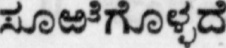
ಸೂಱೆಗೊಳ್ಳದೆ
